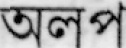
অলপ
